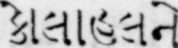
કોલાહલને
